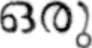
ഒരു
